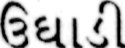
ઉઘાડી
